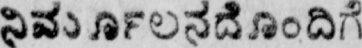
ನಿರ್ಮೂಲನದೊಂದಿಗೆ
